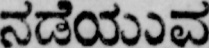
ನಡೆಯುವ
